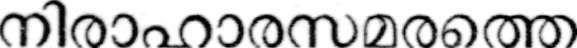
നിരാഹാരസമരത്തെ
